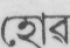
হোৱ
